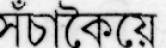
সঁচাকৈয়ে
